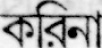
করিনা
